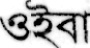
ওইবা
